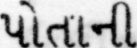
પોતાની
